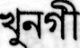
খুনগী
